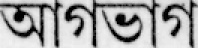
আগভাগ
